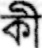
কী
